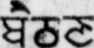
ਬੈਠਣ
